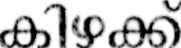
കിഴക്ക്
